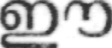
ഈ
